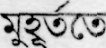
মুহূর্ততে
